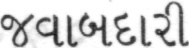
જવાબદારી
